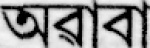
অৱাবা
